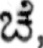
ಚೆ,
